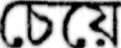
চেয়ে
